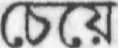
চেয়ে
